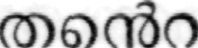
തന്റെ
